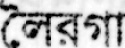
লৈরগা
